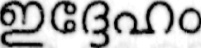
ഇദ്ദേഹം
